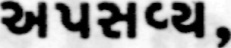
અપસવ્ય,
